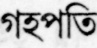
গহপতি
